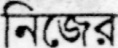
নিজের
